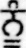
ਨੂੰ
